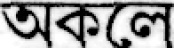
অকলে
